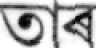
তাৰ
